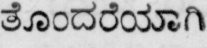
ತೊಂದರೆಯಾಗಿ
